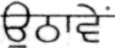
ਉਠਾਵੇਂ
